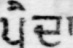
ਪੈਦਾ
